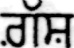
ਗ਼ੱਸ਼
